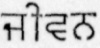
ਜੀਵਨ
